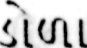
ડોળા
